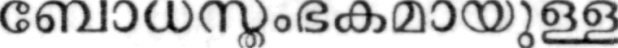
ബോധസ്തംഭകമായുള്ള
